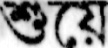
শুয়ে
